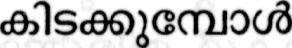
കിടക്കുമ്പോള്‍
